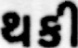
થકી
